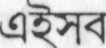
এইসব
